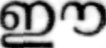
ഈ
